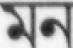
মন
